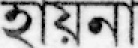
হায়না
